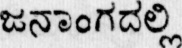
ಜನಾಂಗದಲ್ಲಿ
